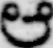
ಆ
